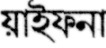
য়াইফনা
